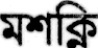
মশক্নি
